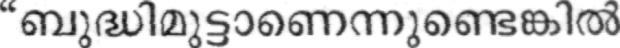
“ബുദ്ധിമുട്ടാണെന്നുണ്ടെങ്കില്‍
